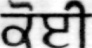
ਕੋਈ
